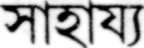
সাহায্য
